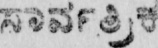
ಸಾರ್ವತ್ರಿಕ
